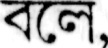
বলে,
